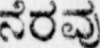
ನೆರವು
